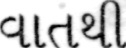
વાતથી
